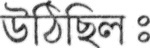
উঠিছিলঃ
